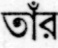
তাঁর
